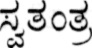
ಸ್ವತಂತ್ರ
